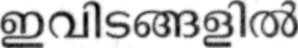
ഇവിടങ്ങളില്‍
